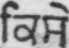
ਕਿਸੇ
